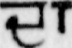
ਦਾ
